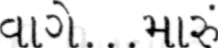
વાગે...મારું
